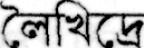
লৈখিদ্রে
